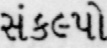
સંકલ્પો
